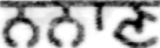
ਨਨਾਣ
